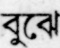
বুঝে
